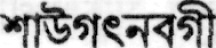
শাউগৎনবগী
